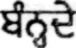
ਬੰਨ੍ਹਦੇ
